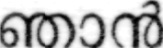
ഞാന്‍
